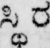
ಸ್ಥಿರ
